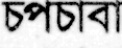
চপচাবা
